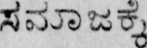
ಸಮಾಜಕ್ಕೆ
